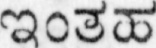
ಇಂತಹ
